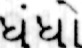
ધંધો
